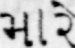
મારે
